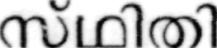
സ്ഥിതി
